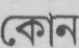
কোন
